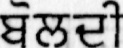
ਬੋਲਦੀ
